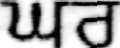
ਘਰ
